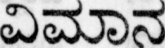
ವಿಮಾನ
